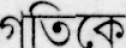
গতিকে
